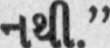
નથી."
